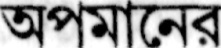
অপমানের
